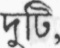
দুটি,
